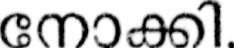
നോക്കി.
